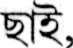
ছাই,
